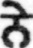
ਨੇ
